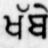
ਖੱਬੇ
